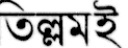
তিল্লমই
